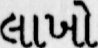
લાખો
